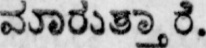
ಮಾರುತ್ತಾರೆ.
